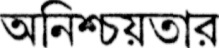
অনিশ্চয়তার
